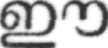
ഈ
